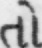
તો
